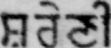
ਸ਼ਰੇਣੀ
